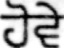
ਹੋਵੇ
